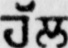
ਹੱਲ
